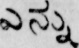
ಎನ್ನು
